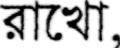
রাখো,
